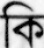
কি
